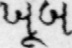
ખૂબ
